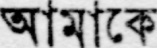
আমাকে
